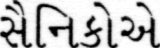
સૈનિકોએ
